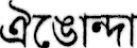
ঐঙোন্দা
